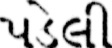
પડેલી
